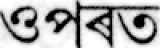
ওপৰত
